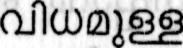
വിധമുള്ള
